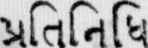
પ્રતિનિધિ
